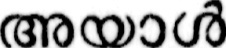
അയാള്‍
